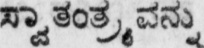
ಸ್ವಾತಂತ್ರ್ಯವನ್ನು
